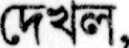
দেখল,
